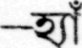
-হ্যাঁ
